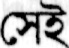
সেই
